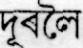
দূৰলৈ
